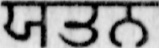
ਯਤਨ
